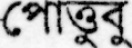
পোত্তুবু
